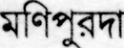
মণিপুরদা
